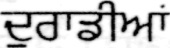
ਦੁਰਾਡੀਆਂ
